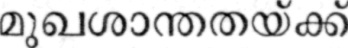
മുഖശാന്തതയ്ക്ക്
